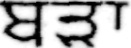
ਬੜਾ
